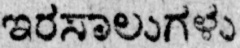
ಇರಸಾಲುಗಳು
